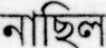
নাছিল
